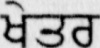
ਖੇਤਰ
